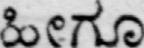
ಹೀಗೂ
